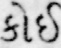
કોઈ
